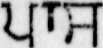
ਪਾਸ
